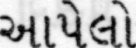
આપેલાં
